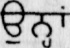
ਉਨ੍ਹਾਂ
